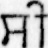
ਸੀ
